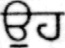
ਉਹ
